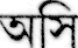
অসি
